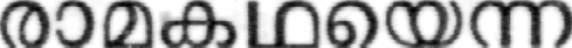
രാമകഥയെന്ന
